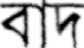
বাদ
